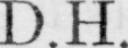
D.H.
